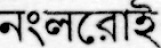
নংলরোই
